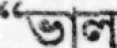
"ভাল
